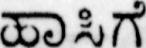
ಹಾಸಿಗೆ
